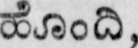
ಹೊಂದಿ,
